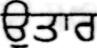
ਉਤਾਰ
